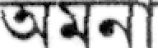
অমনা
